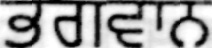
ਭਗਵਾਨ
